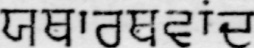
ਯਥਾਰਥਵਾਂਦ
